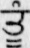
ਤੂੰ
